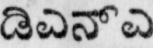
ಡಿಎನ್‌ಎ
